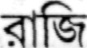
রাজি
